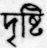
দৃষ্টি
